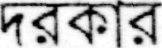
দরকার
